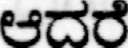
ಆದರೆ
